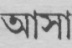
আসা
